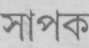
সাপক
